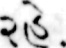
રહે.
